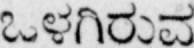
ಒಳಗಿರುವ
